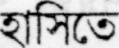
হাসিতে
